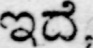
ಇದೆ,
